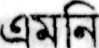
এমনি
